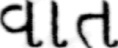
વાત
